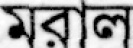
মরাল
